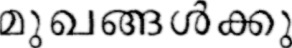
മുഖങ്ങള്‍ക്കു
